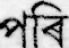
পৰি
